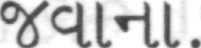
જવાના.
